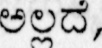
ಅಲ್ಲದೆ,
